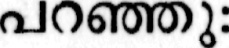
പറഞ്ഞു:
